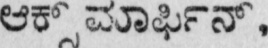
ಆಕ್ಸ್‌ಮಾರ್ಫಿನ್,
